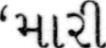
'મારી
